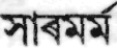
সাৰমৰ্ম
